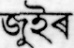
জুইৰ
